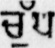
ਚੁੱਪ
